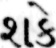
શકે
